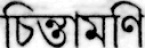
চিন্তামণি
